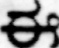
ಈ
